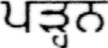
ਪੜ੍ਹਨ
